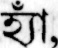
হ্যাঁ,
